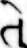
તે
